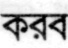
করব
